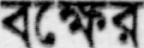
বক্ষের
